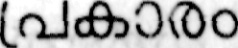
പ്രകാരം
